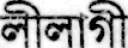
লীলাগী
